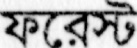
ফরেস্ট
